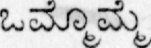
ಒಮ್ಮೊಮ್ಮೆ
